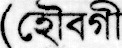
(হৌবগী
